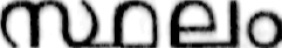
സ്ഥലം
